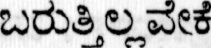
ಬರುತ್ತಿಲ್ಲವೇಕೆ
